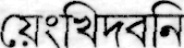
য়েংখিদবনি
